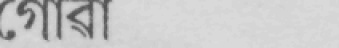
গোৱা
